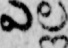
ಎಲ್ಲ
